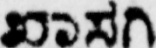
ಖಾಸಗಿ
